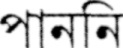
পাননি
